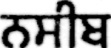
ਨਸੀਬ
